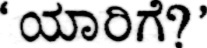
'ಯಾರಿಗೆ?'
